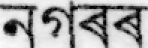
নগৰৰ
